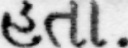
હતા.
